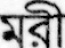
মরী
